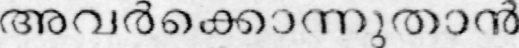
അവര്‍ക്കൊന്നുതാന്‍
